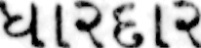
ધારદાર
